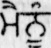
ਮੈਨੂੰ
